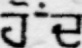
ਹੋਂਦ
